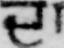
ਦਾ
